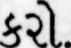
કરો.
